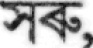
সৰু,
